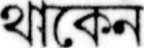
থাকেন
